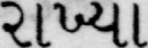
રાખ્યા
